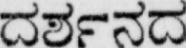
ದರ್ಶನದ
